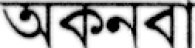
অকনবা
